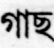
গাছ
